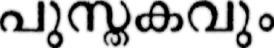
പുസ്തകവും
